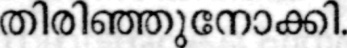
തിരിഞ്ഞുനോക്കി.
